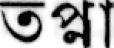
তপ্না
